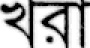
খরা
